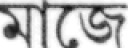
মাজে
